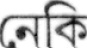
নেকি
